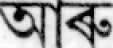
আৰু
